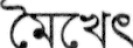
মৈখেৎ
